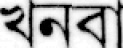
খনবা
